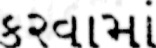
કરવામાં
